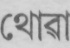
থোৱা
